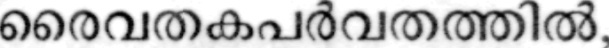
രൈവതകപര്‍വതത്തില്‍,
